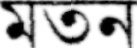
মতন
